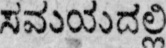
ಸಮಯದಲ್ಲಿ
